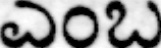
ಎಂಬ
